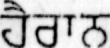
ਹੈਰਾਨ
